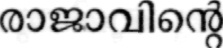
രാജാവിന്റെ
